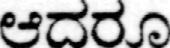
ಆದರೂ
